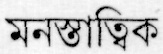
মনস্তাত্বিক
